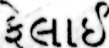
ફેલાઈ
